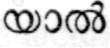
യാല്‍
